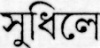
সুধিলে
